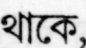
থাকে,
